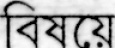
বিষয়ে
